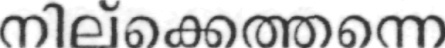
നില്ക്കെത്തന്നെ
